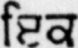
ਇਕ
